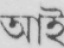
আই
